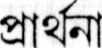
প্রার্থনা
